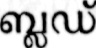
ബ്ലഡ്
